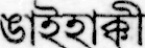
ঙাইহাক্কী
